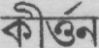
কীৰ্ত্তন
